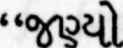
"જણ્યો
